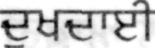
ਦੁਖਦਾਈ
